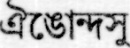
ঐঙোন্দসু
